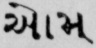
ઓમ્
